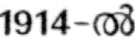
1914-ല്‍
